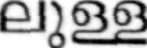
ലുള്ള
